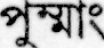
পুম্মাং
